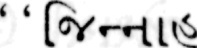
"જિન્નાહ
